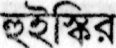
হুইস্কির
